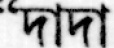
“দাদা
